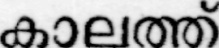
കാലത്ത്
